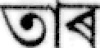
তাৰ
